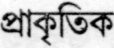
প্রাকৃতিক
